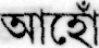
আহোঁ
